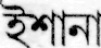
ইশানা
